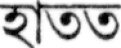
হাতত
